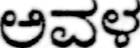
ಅವಳ
